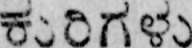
ಕುರಿಗಳು
